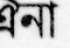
ঐনা
